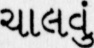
ચાલવું
